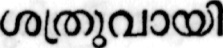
ശത്രുവായി
